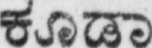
ಕೂಡಾ
